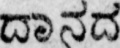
ದಾನದ
